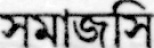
সমাজসি
